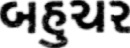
બહુચર
